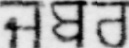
ਜਬਰ
